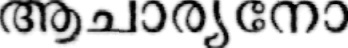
ആചാര്യനോ
